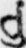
તું
